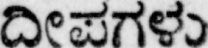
ದೀಪಗಳು
